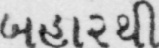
બહારથી
